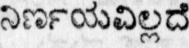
ನಿರ್ಣಯವಿಲ್ಲದೆ
